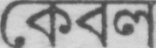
কেবল
